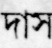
দাস
